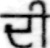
ਦੀ
